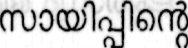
സായിപ്പിന്റെ
